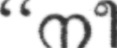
"നീ
